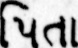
પિતા
